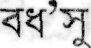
বধ’সু
